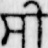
ਸੀ
